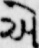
એ
